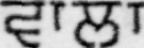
ਵਾਲਾ
